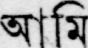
আমি
